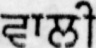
ਵਾਲੀ
